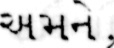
અમને,
